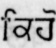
ਕਿਹੋ
